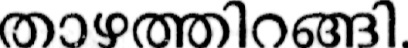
താഴത്തിറങ്ങി.
